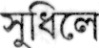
সুধিলে
